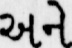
અને
